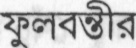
ফুলবন্তীর
